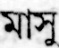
মাসু
